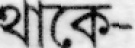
থাকে-
